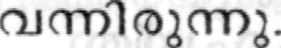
വന്നിരുന്നു.
